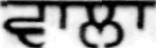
ਵਾਲਾ
